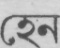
হেন
